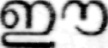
ഈ
